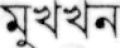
মুখখন
